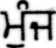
ਮੁੰਜ
